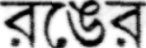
রঙের
